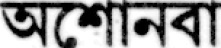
অশোনবা
